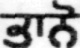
ਭਾਨੋ
